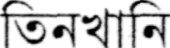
তিনখানি
